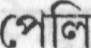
পেলি
